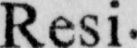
Resi-
